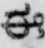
ಈ
